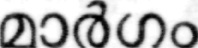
മാര്‍ഗം
